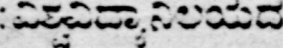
:ವಿಶ್ವವಿದ್ಯಾನಿಲಯದ
